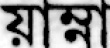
য়াম্না
